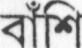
বাঁশি
